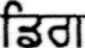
ਡਿਗ
